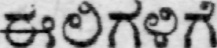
ಈಲಿಗಳಿಗೆ
